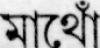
মাথোঁ
